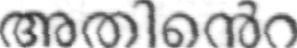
അതിന്റെ
